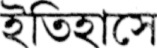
ইতিহাসে
